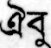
ঐবু
